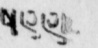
ષણણ
